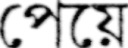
পেয়ে
